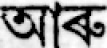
আৰু
